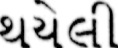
થયેલી
